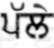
ਪੱਲੇ
